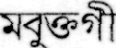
মবুক্তগী
